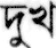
দুখ
